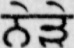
ਨੇੜੇ
